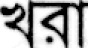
খরা
